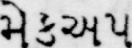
મેકઅપ
